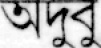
অদুবু
